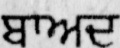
ਬਾਅਦ
